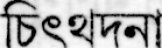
চিৎথদনা
